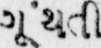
ગૂંથતી
